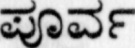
ಪೂರ್ವ
